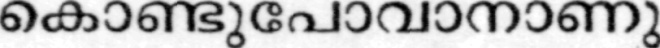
കൊണ്ടുപോവാനാണു
